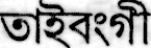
তাইবংগী
